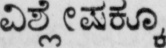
ವಿಶ್ಲೇಷಕ್ಕೂ
